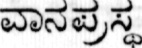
ವಾನಪ್ರಸ್ಥ
